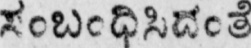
ಸಂಬಂಧಿಸಿದಂತೆ
